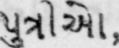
પુત્રીઓ,
